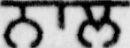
ਨਾਲ
